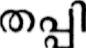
തപ്പി
